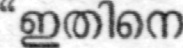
"ഇതിനെ
